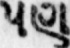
પણ
